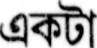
একটা
